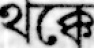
থক্কে
